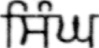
ਸਿੰਘ
